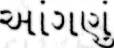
આંગણું
